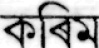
কৰিম
